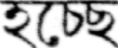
হচ্ছে
